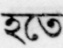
হতে
